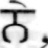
ਨੇ,
